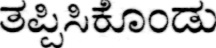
ತಪ್ಪಿಸಿಕೊಂಡು
